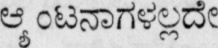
ಆಂಟೆನಾಗಳಲ್ಲದೇ
